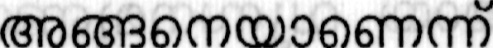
അങ്ങനെയാണെന്ന്
